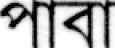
পাবা
